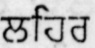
ਲਹਿਰ
